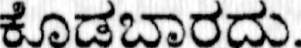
ಕೊಡಬಾರದು.
